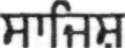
ਸਾਜਿਸ਼
